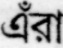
এঁরা
